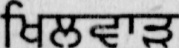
ਖਿਲਵਾੜ
